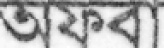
অফবা
